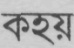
কহয়
